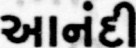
આનંદી
